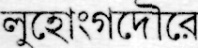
লুহোংগদৌরে
